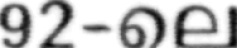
92-ലെ
